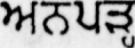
ਅਨਪੜ੍ਹ
